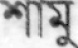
শামু
